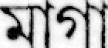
মাগা
